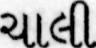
ચાલી
